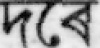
দৰে
